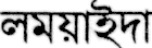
লময়াইদা
